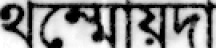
থম্মোয়দা
